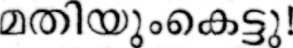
മതിയുംകെട്ടു!
